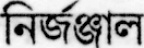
নির্জঞ্জাল
